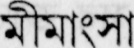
মীমাংসা
